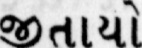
જીતાયો
